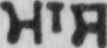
ਮਾਸ
